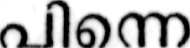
പിന്നെ
